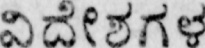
ವಿದೇಶಗಳ
